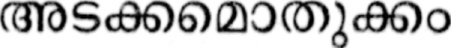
അടക്കമൊതുക്കം
